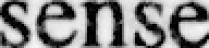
sense
